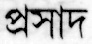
প্রসাদ
